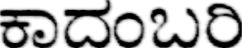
ಕಾದಂಬರಿ
